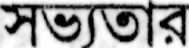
সভ্যতার
